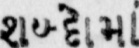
શબ્દોમાં
